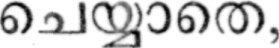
ചെയ്യാതെ,
